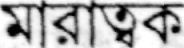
মারাত্বক
